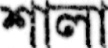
শালা
